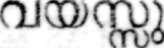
വയസ്സു
